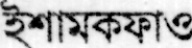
ইশামকফাও
